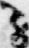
કે
